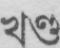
খণ্ড
